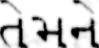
તેમને
